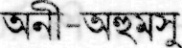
অনী-অহুমসু
